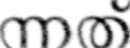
ന്നത്
